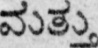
ಮತ್ತು
